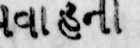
પ્રવાહની
